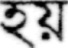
হয়
